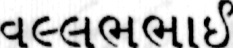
વલ્લભભાઈ
